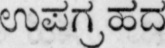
ಉಪಗ್ರಹದ
